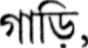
গাড়ি,
